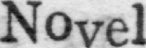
Novel
